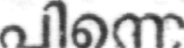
പിന്നെ
